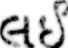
લઈ
